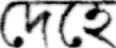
দেহে
